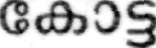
കോട്ട
